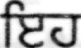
ਇਹ
